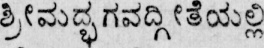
ಶ್ರೀಮದ್ಭಗವದ್ಗೀತೆಯಲ್ಲಿ
